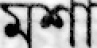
মশা
